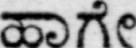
ಹಾಗೇ
